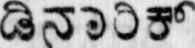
ಡಿನಾರಿಕ್
